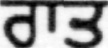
ਰਾਤ
